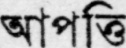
আপত্তি
